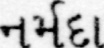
નર્મદા
